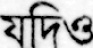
যদিও
